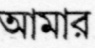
আমার
